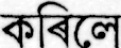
কৰিলে
